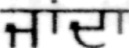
ਜਾਂਦਾ
